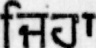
ਜਿਹਾ
